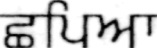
ਛਪਿਆ
